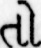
તો
